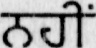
ਨਹੀਂ
